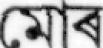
মোৰ
